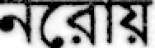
নরোয়
